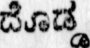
ದೊಡ್ಡ
